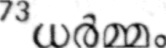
73ധര്‍മ്മം
